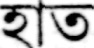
হাত
